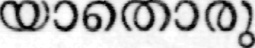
യാതൊരു
